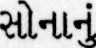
સોનાનું
